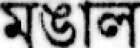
মঙাল
